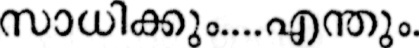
സാധിക്കും....എന്തും.
